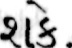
શકે.
